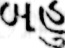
બહુ
